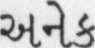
અનેક
